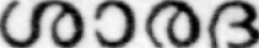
ശാരദ
